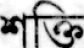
শক্তি
